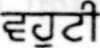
ਵਹੁਟੀ
